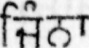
ਜਿੰਨਾ
